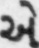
એ
